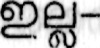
ഇല്ല-
